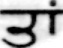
ਤਾਂ
